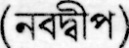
(নবদ্বীপ)
